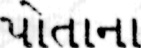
પોતાના
